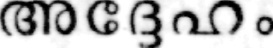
അദ്ദേഹം
